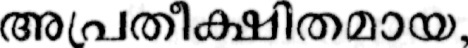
അപ്രതീക്ഷിതമായ,
